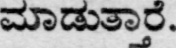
ಮಾಡುತ್ತಾರೆ.
